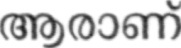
ആരാണ്
